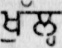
ਖੁੱਲ੍ਹ
